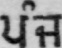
ਪੰਜ
